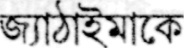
জ্যাঠাইমাকে
